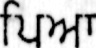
ਪਿਆ
